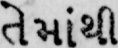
તેમાંથી
